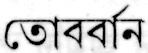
তোর্ব্বান
